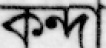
কন্দা
